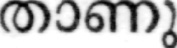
താണു
